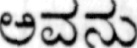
ಅವನು
